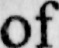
of
